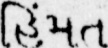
હિંમત
